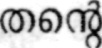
തന്റെ
